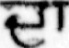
ਦਾ
